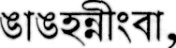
ঙাঙহন্নীংবা,
